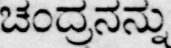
ಚಂದ್ರನನ್ನು
